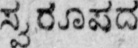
ಸ್ವರೂಪದ
